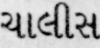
ચાલીસ
